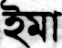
ইমা
